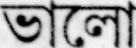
ভালো
